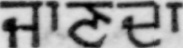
ਜਾਣਦਾ
